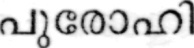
പുരോഹി
